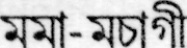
মমা-মচাগী
